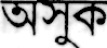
অসুক
